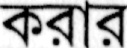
করার
